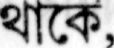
থাকে,
